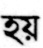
হয়
